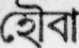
হৌবা
